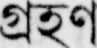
গ্রহণ
